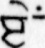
ਏਂ
